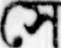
সে
